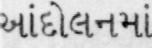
આંદોલનમાં
